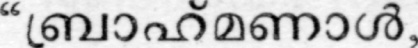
"ബ്രാഹ്മണാള്‍,
